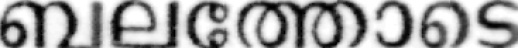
ബലത്തോടെ
